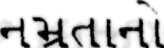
નમ્રતાનો
